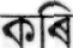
কৰি
